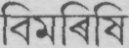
বিমৰিষি
